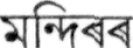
মন্দিৰৰ
